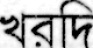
খরদি
